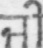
ਜੀ
